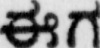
ಈಗ
